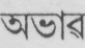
অভাৱ
